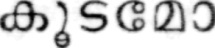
കൂടമോ
